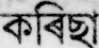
কৰিছা
